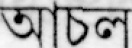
আচল
